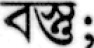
বস্তু;
